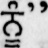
ਨੂੰ''
